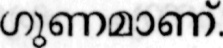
ഗുണമാണ്.
